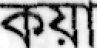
কয়া
